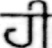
ਹੀ
